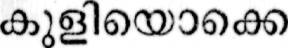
കുളിയൊക്കെ
